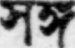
সঙ্গ
